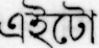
এইটো
